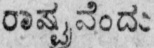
ರಾಷ್ಟ್ರವೆಂದು
